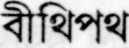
বীথিপথ
